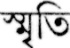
স্মৃতি
